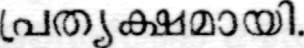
പ്രത്യക്ഷമായി.
